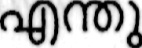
എന്തു
